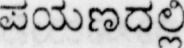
ಪಯಣದಲ್ಲಿ
